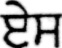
ਏਸ
